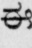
ಈ
